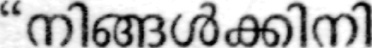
“നിങ്ങള്‍ക്കിനി
